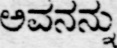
ಅವನನ್ನು
